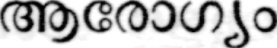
ആരോഗ്യം
